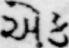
એક
